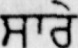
ਸਾਰੇ
